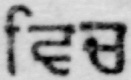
ਵਿਚ
